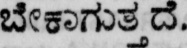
ಬೇಕಾಗುತ್ತದೆ.
